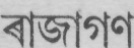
ৰাজাগণ
